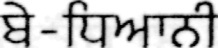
ਬੇ-ਧਿਆਨੀ
